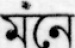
মঁনে
